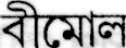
বীমোল
